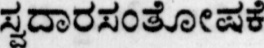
ಸ್ವದಾರಸಂತೋಷಕೆ
